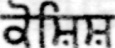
ਕੋਸ਼ਿਸ਼
